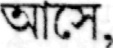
আসে,
